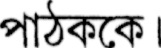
পাঠককে।
